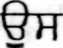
ਉਸ
